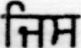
ਜਿਸ
